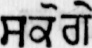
ਸਕੋਗੇ
